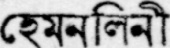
হেমনলিনী
